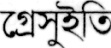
গ্রেসুইতি
